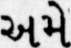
અમે
